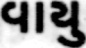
વાયુ
